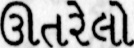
ઊતરેલો
